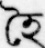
হৈ
